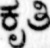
ಕೃತಿ
